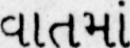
વાતમાં
